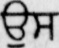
ਉਸ
